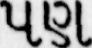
પણ
